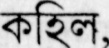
কহিল,
